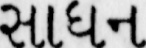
સાધન
